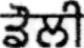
ਡੌਲੀ
